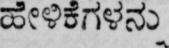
ಹೇಳಿಕೆಗಳನ್ನು
